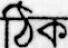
ঠিক
